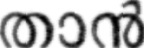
താന്‍
